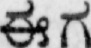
ಈಗ
